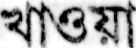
খাওয়া
